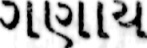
ગણાય
